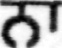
ਨਾ
